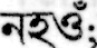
নহওঁ;
